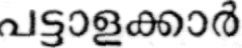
പട്ടാളക്കാര്‍
